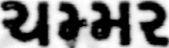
ચમ્મર
